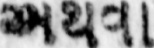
અથવા
